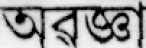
অৱজ্ঞা
